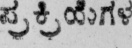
ಪ್ರಕ್ರಿಯಗಳ
